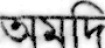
অমদি
